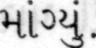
માંગ્યું.
